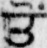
ਤੋਂ
